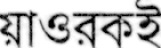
য়াওরকই
